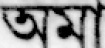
অমা
